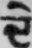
ਦੇ
